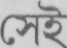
সেই
